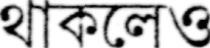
থাকলেও
